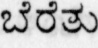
ಬೆರೆತು
